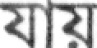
যায়
